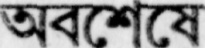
অবশেষে
